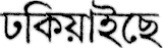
ঢকিয়াইছে
